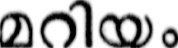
മറിയം
